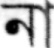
না
